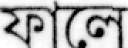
ফালে
